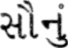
સૌનું
